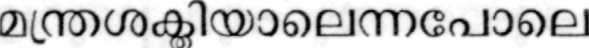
മന്ത്രശക്തിയാലെന്നപോലെ
